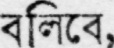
বলিবে,
